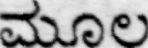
ಮೂಲ
